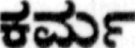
ಕರ್ಮ
